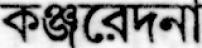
গঞ্জরেদনা
